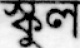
স্কুল
